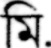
মি.
